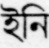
ইনি
